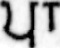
ਪਾ
